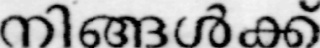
നിങ്ങള്‍ക്ക്
